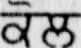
ਕੋਲ
